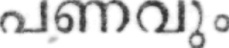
പണവും
